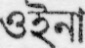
ওইনা
